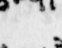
કન્યા
